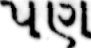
પણ
